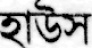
হাউস
